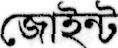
জোইন্ট
